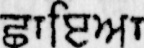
ਛਾਇਆ
